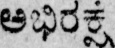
ಅಭಿರಕ್ಷ
